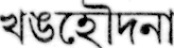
খঙহৌদনা
